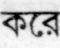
করে
